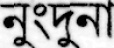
নুংদুনা
